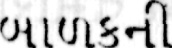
બાળકની
